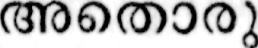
അതൊരു
